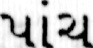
પાંચ
